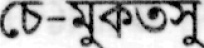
চে-মুকতসু
